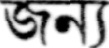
জন্য
